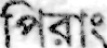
পিরাং
